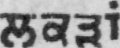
ਲਕੜਾਂ
